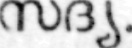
സദ്യ.
